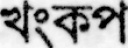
খংকপ
